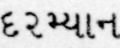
દરમ્યાન
